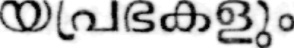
യപ്രഭകളും
